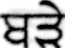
ਬੜੇ
